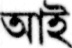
আই
